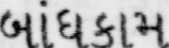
બાંધકામ
